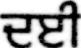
ਦਈ
